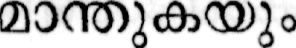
മാന്തുകയും
